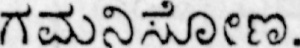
ಗಮನಿಸೋಣ.
